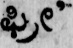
ಫ್ರೀ’
